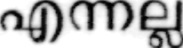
എന്നല്ല
